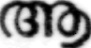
ആ
